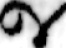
જ
